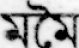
মমৈ
